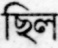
ছিল
